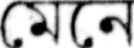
মেনে
